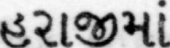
હરાજીમાં
